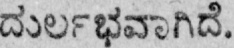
ದುರ್ಲಭವಾಗಿದೆ.
